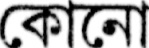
কোনো
